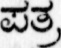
ಪತ್ರ
